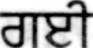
ਗਈ
